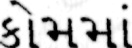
કોમમાં
